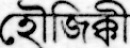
হৌজিক্কী
